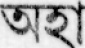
অহা
